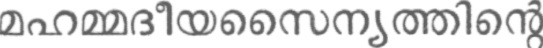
മഹമ്മദീയസൈന്യത്തിന്റെ
